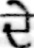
ਦੇ
